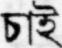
চাই
